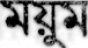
ময়ুম
